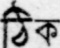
ঠিক
